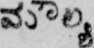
ಮೌಲ್ಯ
